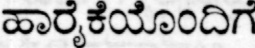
ಹಾರೈಕೆಯೊಂದಿಗೆ
